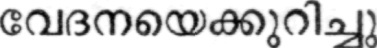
വേദനയെക്കുറിച്ചു
